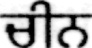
ਚੀਨ
